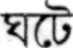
ঘটে
